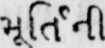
મૂર્તિની
